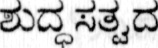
ಶುದ್ಧಸತ್ವದ
